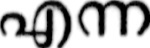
എന്ന
